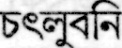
চৎলুবনি
